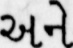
અને
